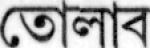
তোলাব
